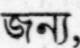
জন্য,
